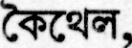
কৈথেল,
